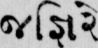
જજ્ઞિરે
